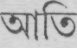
আতি
